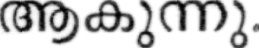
ആകുന്നു.
